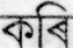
কৰি
